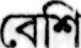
বেশি
